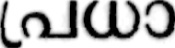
പ്രധാ
